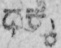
ಧಕ್ಕೆ
